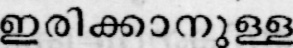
ഇരിക്കാനുള്ള
